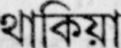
থাকিয়া
